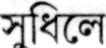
সুধিলে
